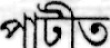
পাটীত
